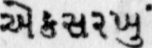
એકસરખું
